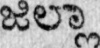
ಜಿಲ್ಲಾ
